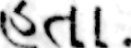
હતા.
